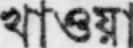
খাওয়া
